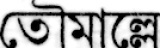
তৌমাল্লে
